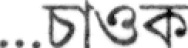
...চাওক
